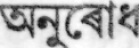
অনুৰোধ
